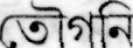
তৌগনি
